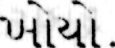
ખોયો.
